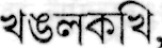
খঙলকখি,
